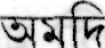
অমদি
